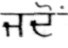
ਜਦੋਂ
